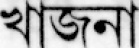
খাজনা
